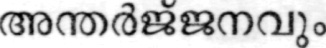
അന്തര്‍ജ്ജനവും
